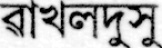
ৱাখলদুসু
